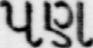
પણ
